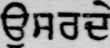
ਉਸਰਦੇ
